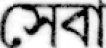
সেবা
